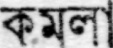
কমলা
